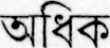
অধিক
